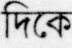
দিকে
